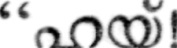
"ഹയ്!
